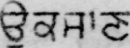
ਉਕਸਾਣ
